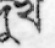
দুখ
